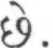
છે.
